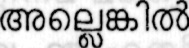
അല്ലെങ്കില്‍
